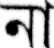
না
